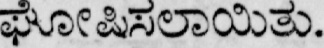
ಘೋಷಿಸಲಾಯಿತು.
